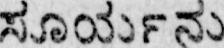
ಸೂರ್ಯನು
